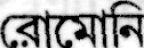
রোমোনি
